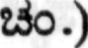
ಚ೦.)
